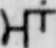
ਮਾਂ
